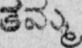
ತಮ್ಮ
